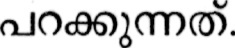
പറക്കുന്നത്.
